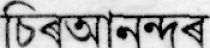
চিৰআনন্দৰ
